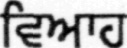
ਵਿਆਹ
